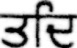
ਤਦਿ
